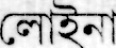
লোইনা
